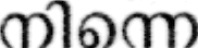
നിന്നെ
